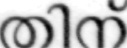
തിന്
